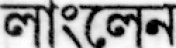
লাংলেন
